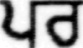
ਪਰ
